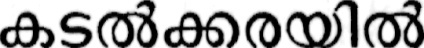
കടല്‍ക്കരയില്‍
